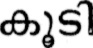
കൂടി
